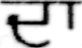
ਦਾ
